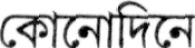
কোনোদিনে
